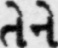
તેને
